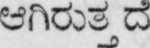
ಆಗಿರುತ್ತದೆ
